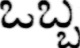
ಒಬ್ಬ
